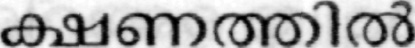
ക്ഷണത്തില്‍
